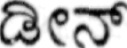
ಡೀನ್
